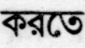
করতে
